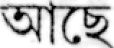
আছে
